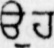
ਉਹ
